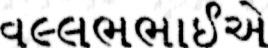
વલ્લભભાઈએ
